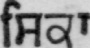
ਸਿਕਾ
